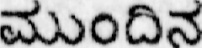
ಮುಂದಿನ
